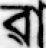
ৱা
